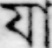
যা
